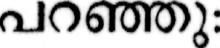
പറഞ്ഞു:
